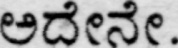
ಅದೇನೇ.
